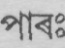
পাৰঃ
